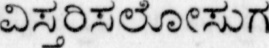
ವಿಸ್ತರಿಸಲೋಸುಗ
